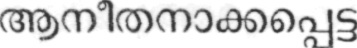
ആനീതനാക്കപ്പെട്ട
